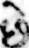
છે
